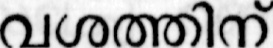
വശത്തിന്
